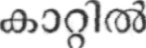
കാറ്റില്‍
